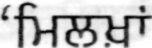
'ਮਿਲਖ਼ਾਂ
